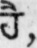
ਹੈ,
